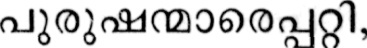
പുരുഷന്മാരെപ്പറ്റി,
